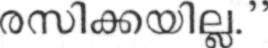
രസിക്കയില്ല."
